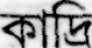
কাদ্রি
